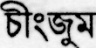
চীংজুম
